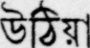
উঠিয়া
